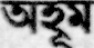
অহূম
